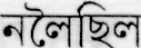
নলৈছিল
